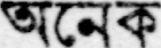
অনেক
